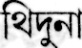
থিদুনা
